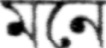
মনে
